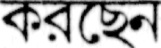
করছেন
